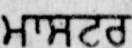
ਮਾਸਟਰ
